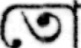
তো
